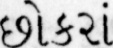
છોકરાં
